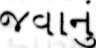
જવાનું
